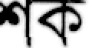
শক
